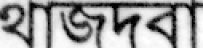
থাজদবা
